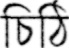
চিঠি
